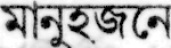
মানুহজনে
